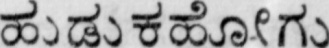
ಹುಡುಕಹೋಗು
